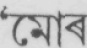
'মোৰ
